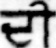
ਦੀ
